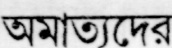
অমাত্যদের
